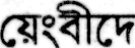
য়েংবীদে
